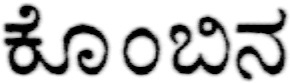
ಕೊಂಬಿನ
